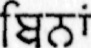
ਬਿਨਾਂ
